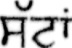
ਸੱਟਾਂ
